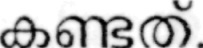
കണ്ടത്.
